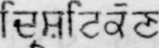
ਦ੍ਰਿਸ਼ਟਿਕੋਣ
